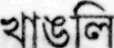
খাঙলি
